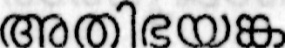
അതിഭയങ്ക
